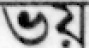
ভয়
